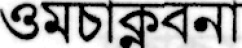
ওমচাক্নবনা
